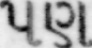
પણ
